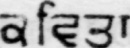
ਕਵਿਤਾ
